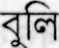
বুলি
